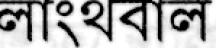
লাংথবাল
